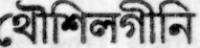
থৌশিলগীনি
